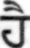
ਹੈ
